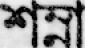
শম্না
